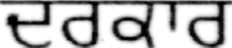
ਦਰਕਾਰ
